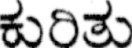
ಕುರಿತು
